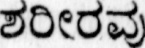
ಶರೀರವು
